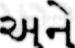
અને
